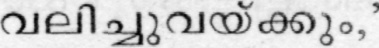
വലിച്ചുവയ്ക്കും,'
